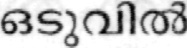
ഒടുവില്‍
